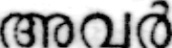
അവര്‍
